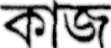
কাজ
